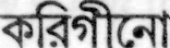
করিগীনো
